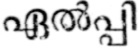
ഏല്‍പ്പി
